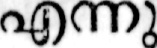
എന്നു
